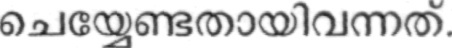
ചെയ്യേണ്ടതായിവന്നത്
